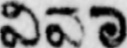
ವಿವಾ
